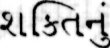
શક્તિનું
